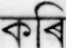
কৰি
